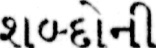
શબ્દોની
